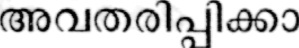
അവതരിപ്പിക്കാ
